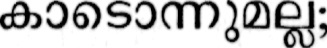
കാടൊന്നുമല്ല;
